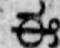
ಈ
